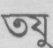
তযু
